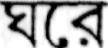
ঘরে
